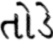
તોડે
